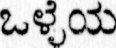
ಒಳ್ಳೆಯ
